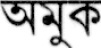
অমুক
